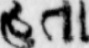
હતા
